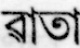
ৱাতা
